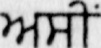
ਅਸੀਂ
